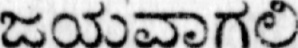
ಜಯವಾಗಲಿ
